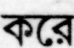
করে
